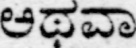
ಅಥವಾ
